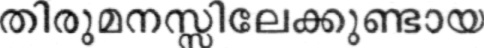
തിരുമനസ്സിലേക്കുണ്ടായ
